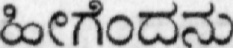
ಹೀಗೆಂದನು
